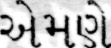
એમણે
